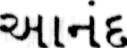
આનંદ
